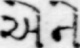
એને
